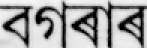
বগৰাৰ
